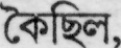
কৈছিল,
